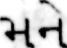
મને
